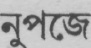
নুপজে
